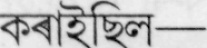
কৰাইছিল-
